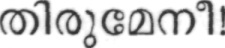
തിരുമേനീ!
